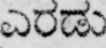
ಎರಡು
